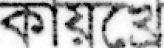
কায়খ্রে
